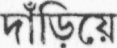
দাঁড়িয়ে
